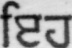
ਇਹ
